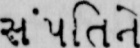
સંપતિને
